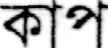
কাপ
